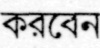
করবেন
